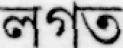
লগত
